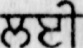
ਲਈ
